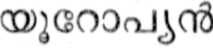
യൂറോപ്യന്‍
